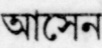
আসেন
